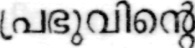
പ്രഭുവിന്റെ
